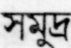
সমুদ্র
